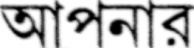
আপনার
